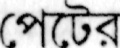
পেটের
